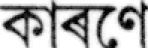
কাৰণে
